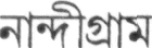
নান্দীগ্রাম
